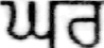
ਘਰ
